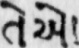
તેઓ
